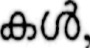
കള്‍,
